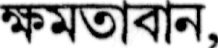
ক্ষমতাবান,
